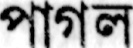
পাগল
